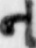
ન
